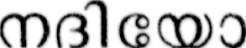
നദിയോ
